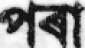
পৰা
